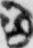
છે
